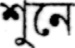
শুনে
